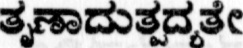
ತೃಣಾದುತ್ಪದ್ಯತೇ
